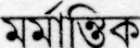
মর্মান্তিক
